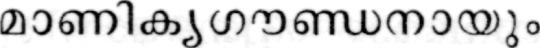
മാണിക്യഗൌണ്ഡനായും
